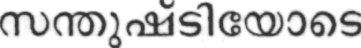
സന്തുഷ്ടിയോടെ
